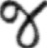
જ
